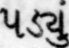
પડ્યું
